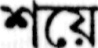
শয়ে
